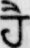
ਹੈ
